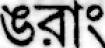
ঙরাং
